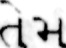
તેમ
